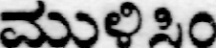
ಮುಳಿಸಿಂ
